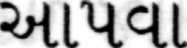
આપવા
